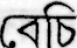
বেচি
